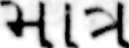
માત્ર
